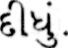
દીધું.
